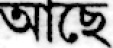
আছে
